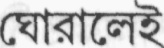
ঘোরালেই
